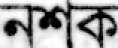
নশক
